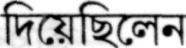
দিয়েছিলেন
